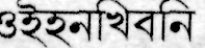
ওইহনখিবনি
